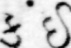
કંઈ
